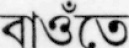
বাওঁতে
